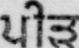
ਪੀੜ
